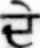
ਦੇ
